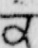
ਕੇ
